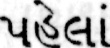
પહેલાં
